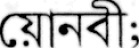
য়োনবী;
